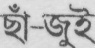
ছাঁ-জুই
